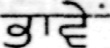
ਭਾਵੇਂ
